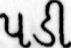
પડી
